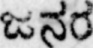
ಜನರ
